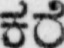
ಕರೆ
